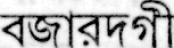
বজারদগী
